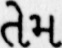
તેમ
